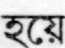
হয়ে
